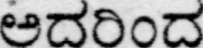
ಅದರಿಂದ
